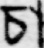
চা
